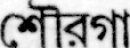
শৌরগা
